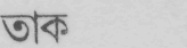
তাক
